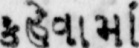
કહેવામાં
